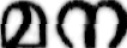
മന
